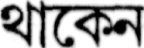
থাকেন
